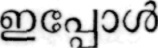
ഇപ്പോള്‍
